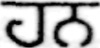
ਹਨ
